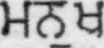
ਮਨੁਖ
